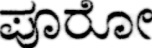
ಪೂರೋ
